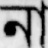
না
